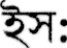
ইস:
